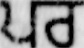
ਪਰ
